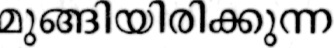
മുങ്ങിയിരിക്കുന്ന
